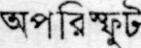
অপরিস্ফুট
